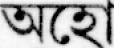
অহো
